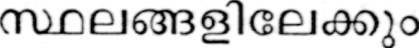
സ്ഥലങ്ങളിലേക്കും
